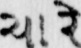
ચારે
